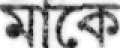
মাকে
